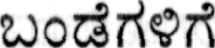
ಬಂಡೆಗಳಿಗೆ
